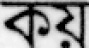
কয়
